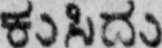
ಕುಸಿದು
